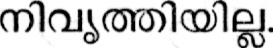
നിവൃത്തിയില്ല.
